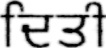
ਦਿਤੀ
